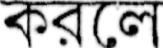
করলে
